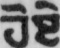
ਹੋਏ
